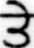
ਤੇ
